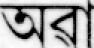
অৱা
